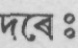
দৰেঃ
